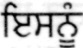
ਇਸਨੂੰ
